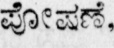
ಪೋಷಣೆ,
